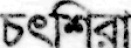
চৎশিরা
